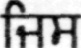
ਜਿਸ
